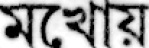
মখোয়
